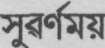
সুৱৰ্ণময়
